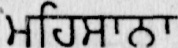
ਮਹਿਸਾਨਾ
